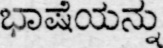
ಭಾಷೆಯನ್ನು
